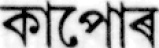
কাপোৰ
